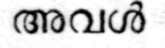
അവള്‍
